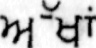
ਅੱਖਾਂ
